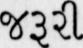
જરૂરી
